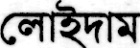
লোইদাম
